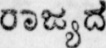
ರಾಜ್ಯದ
